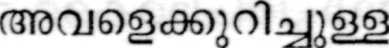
അവളെക്കുറിച്ചുള്ള
